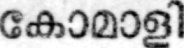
കോമാളി
